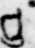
તું
